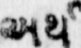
અર્થ
